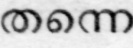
തന്നെ
